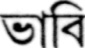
ভাবি
